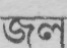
জল
